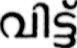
വിട്ട്
